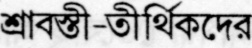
শ্রাবস্তী-তীর্থিকদের
